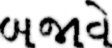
બજાવે
